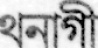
থনাগী
